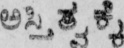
ಅಸ್ತಿತ್ವಕ್ಕೆ
